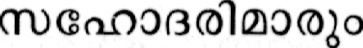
സഹോദരിമാരും
